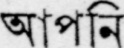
আপনি
